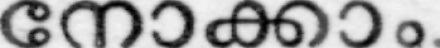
നോക്കാം.
